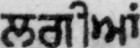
ਲਗੀਆਂ
